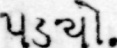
પડ્યો.
